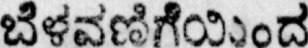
ಬೆಳವಣಿಗೆಯಿಂದ
